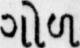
ગોળ
